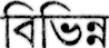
বিভিন্ন
